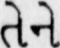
તેને
